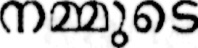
നമ്മുടെ
